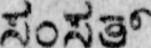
ಸಂಸತ್
